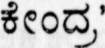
ಕೇಂದ್ರ'
